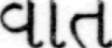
વાત
